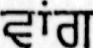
ਵਾਂਗ
